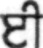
ਈ
